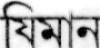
যিমান
